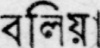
বলিয়া
